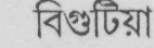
বিগুটিয়া
